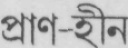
প্ৰাণ-হীন
